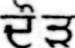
ਦੌੜ
